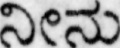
ನೀನು
